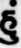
હું
